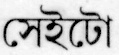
সেইটো
